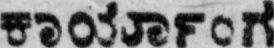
ಕಾರ್ಯಾಂಗ
